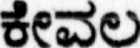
ಕೇವಲ
